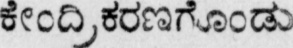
ಕೇಂದ್ರಿಕರಣಗೊಂಡು
